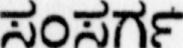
ಸಂಸರ್ಗ
